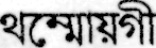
থম্মোয়গী
